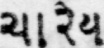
ચારેય
